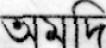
অমদি
